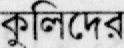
কুলিদের
